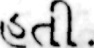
હતી.
